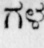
ಗಳ
